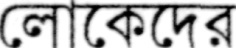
লোকেদের
